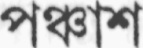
পঞ্চাশ
